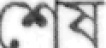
শেষ
